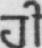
ਹੀ
